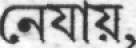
নেযায়,
